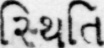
સ્થિતિ
